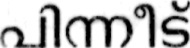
പിന്നീട്
